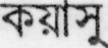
কয়াসু
